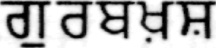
ਗੁਰਬਖ਼ਸ਼
